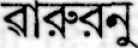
ৱারুরনু
